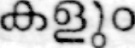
കളും
